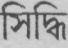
সিদ্ধি
